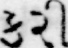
કરી
